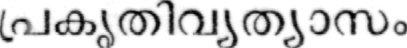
പ്രകൃതിവ്യത്യാസം
